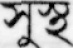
সুস্থ
